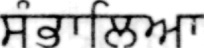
ਸੰਭਾਲਿਆ
